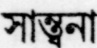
সান্ত্বনা
